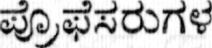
ಪ್ರೊಫೆಸರುಗಳ
